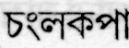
চংলকপা
